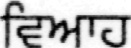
ਵਿਆਹ
